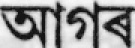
আগৰ
